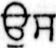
ਉਸ
